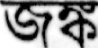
জঙ্ক
